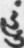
હું
